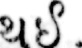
થઈ.
